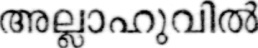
അല്ലാഹുവില്‍
